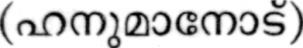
(ഹനുമാനോട്)
